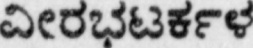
ವೀರಭಟರ್ಕಳ
